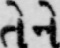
તેને
